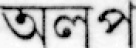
অলপ
